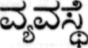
ವ್ಯವಸ್ಥೆ
